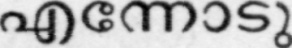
എന്നോടു
